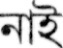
নাই
